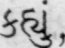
કહ્યું,
